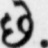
છે.
